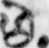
છે.
